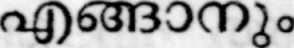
എങ്ങാനും
